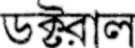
ডক্টরাল
